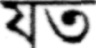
যত
